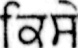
ਕਿਸੇ
